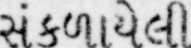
સંકળાયેલી
